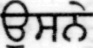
ਉਸਨੇ
